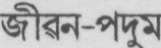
জীৱন-পদুম
